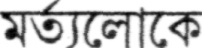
মর্ত্যলোকে
